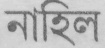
নাহিল
